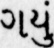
ગયું
